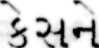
કેસને
